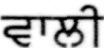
ਵਾਲੀ
